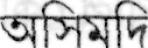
অসিমদি
